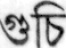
গুচি
